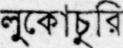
লুকোচুরি
